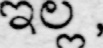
ಇಲ್ಲ,
